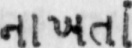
નાખતાં
